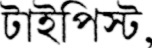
টাইপিস্ট,
